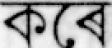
কৰে
